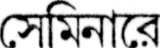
সেমিনারে
